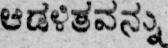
ಆಡಳಿತವನ್ನು
